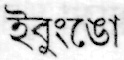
ইবুংঙো
